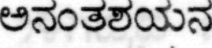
ಅನಂತಶಯನ
